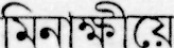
মিনাক্ষীয়ে
